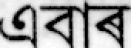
এবাৰ
